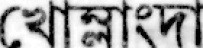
খোম্লাংদা
